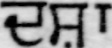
ਦਸ਼ਾ
